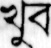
খুব
